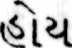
હોય
